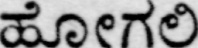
ಹೋಗಲಿ
